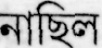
নাছিল
